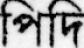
পিদি
